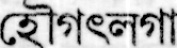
হৌগৎলগা
